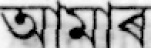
আমাৰ
